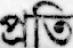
প্রতি
